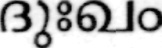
ദുഃഖം
